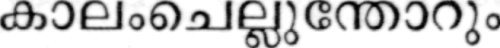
കാലംചെല്ലുന്തോറും
